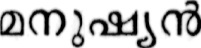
മനുഷ്യന്‍
